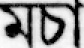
মচা
